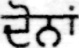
ਦੋਨਾਂ
